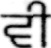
ਵੀ
